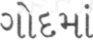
ગોદમાં
